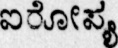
ಐರೋಪ್ಯ
